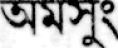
অমসুং
